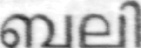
ബലി
